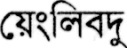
য়েংলিবদু
